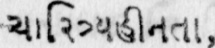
ચારિત્ર્યહીનતા,
